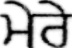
ਮੇਰੇ
